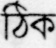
ঠিক
